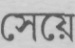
সেয়ে
